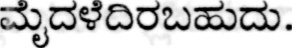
ಮೈದಳೆದಿರಬಹುದು.
